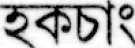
হকচাং
